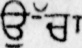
ਉੱਚਾ
